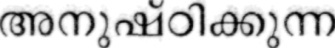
അനുഷ്ഠിക്കുന്ന
